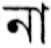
না
